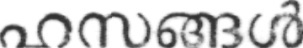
ഹസങ്ങള്‍
